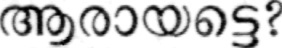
ആരായട്ടെ?
